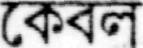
কেবল
